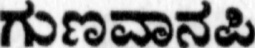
ಗುಣವಾನಪಿ
